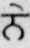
ਨੇ
